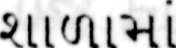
શાળામાં
